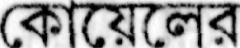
কোয়েলের
